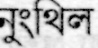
নুংথিল
